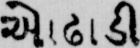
ઓઢાડી
